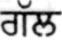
ਗੱਲ
